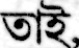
তাই,
